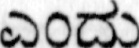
ಎಂದು
